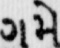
ગમે
